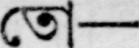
তো—
